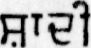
ਸ਼ਾਦੀ
